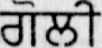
ਗੋਲੀ
